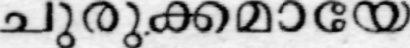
ചുരുക്കമായേ
